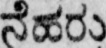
ನೆಹರು
